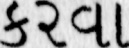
કરવા
